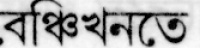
বেঞ্চিখনতে
